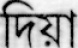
দিয়া
